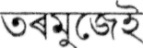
তৰমুজেই
